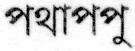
পথাপপু
